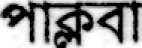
পাক্লবা
